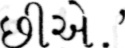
છીએ.'
